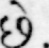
છે.
